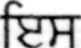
ਇਸ
